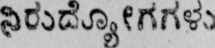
ನಿರುದ್ಯೋಗಗಳು
